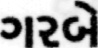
ગરબે
